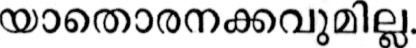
യാതൊരനക്കവുമില്ല.
